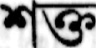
শক্ত
